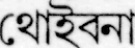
থোইবনা
